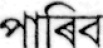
পাৰিব
